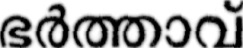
ഭര്‍ത്താവ്
